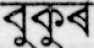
বুকুৰ
